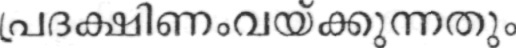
പ്രദക്ഷിണംവയ്ക്കുന്നതും
